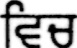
ਵਿਚ
